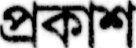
প্রকাশ
